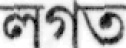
লগত
